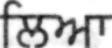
ਲਿਆ
